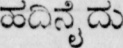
ಹದಿನೈದು
